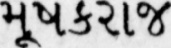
મૂષકરાજ
